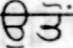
ਉਤੋਂ
